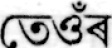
তেওঁৰ
